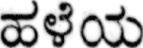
ಹಳೆಯ
